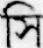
সি
